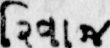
રિવાજ
